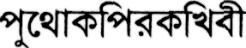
পুথোকপিরকখিবী
